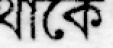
থাকে
